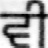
ਵੀ
